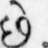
છે.
